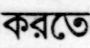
করতে
